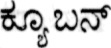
ಕ್ಯೂಬನ್
